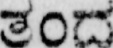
ತಂದ
